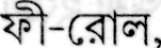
ফী-রোল,
